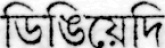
ডিঙিয়েদি
